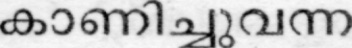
കാണിച്ചുവന്ന
